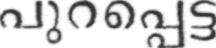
പുറപ്പെട്ട
